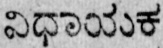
ವಿಧಾಯಕ
